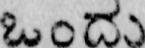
ಒಂದು
